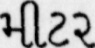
મીટર
